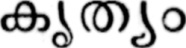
കൃത്യം
